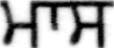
ਮਾਸ
